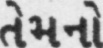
તેમનો
